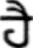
ਹੈ
